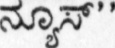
ನ್ಯೂಸ್”
